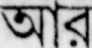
আর
